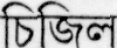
চিজিল
